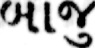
બાજુ
